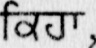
ਕਿਹਾ,
